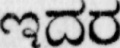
ಇದರ
